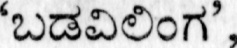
‘ಬಡವಿಲಿಂಗ’,
